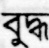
বুদ্ধ
